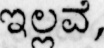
ಇಲ್ಲವೆ,
